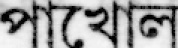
পাখোল
